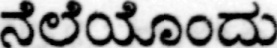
ನೆಲೆಯೊಂದು
